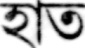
হাত
